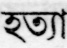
হত্যা
